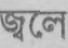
জ্বলে
